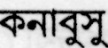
কনাবুসু
